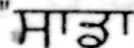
''ਸਾਡਾ
